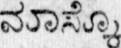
ಮಾಸ್ಕೊ
